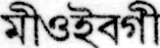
মীওইবগী
